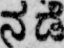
ನಡೆ
